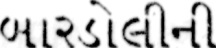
બારડોલીની
